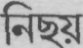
নিছয়
